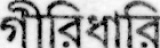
গীরিধারি
